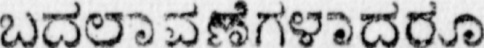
ಬದಲಾವಣೆಗಳಾದರೂ
